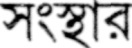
সংস্থার
